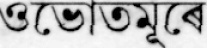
ওভোতমূৰে
